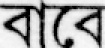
বাবে
